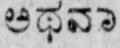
ಅಥವಾ
